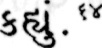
કહ્યું.૬૪
